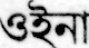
ওইনা
